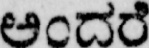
ಅಂದರೆ
